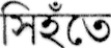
সিহঁতে
